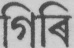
গিৰি
